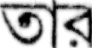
তার
